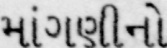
માંગણીનો
